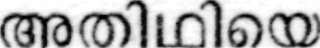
അതിഥിയെ
